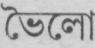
ভৈলো
